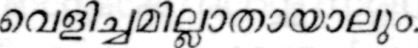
വെളിച്ചമില്ലാതായാലും.
